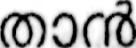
താന്‍
